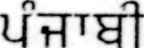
ਪੰਜਾਬੀ
